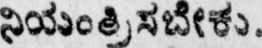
ನಿಯಂತ್ರಿಸಬೇಕು.
